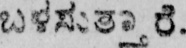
ಬಳಸುತ್ತಾರೆ.
